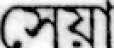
সেয়া
